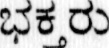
ಭಕ್ತರು
